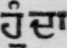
ਹੁੰਦਾ
